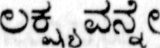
ಲಕ್ಷ್ಯವನ್ನೇ
